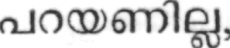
പറയണില്ല,
